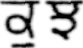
ਕੁਝ
